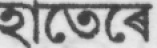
হাতেৰে
